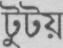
টুটয়
